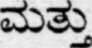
ಮತ್ತು
